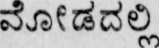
ಮೋಡದಲ್ಲಿ
